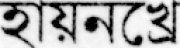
হায়নখ্রে
